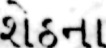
શેઠના
